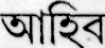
আহিব
